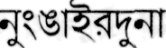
নুংঙাইরদুনা
